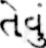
તેવું
